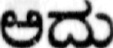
ಅದು
